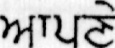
ਆਪਣੇ
